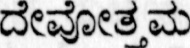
ದೇವೋತ್ತಮ
